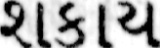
શકાય
